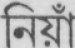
নিয়াঁ
